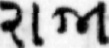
રાજા
